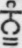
ਨੂੰ
